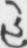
હે
